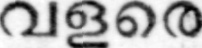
വളരെ
